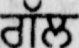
ਗੱਲ
